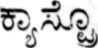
ಕ್ಯಾಸ್ಟ್ರೂ
